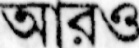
আরও
